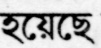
হয়েছে
